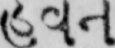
હવન
